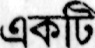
একটি
